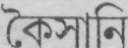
কৈসানি
